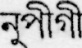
নুপীগী
